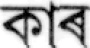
কাৰ
